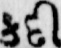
કદી
